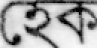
হেক
